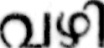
വഴി
